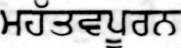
ਮਹੱਤਵਪੂਰਨ
